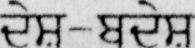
ਦੇਸ਼-ਬਦੇਸ਼
